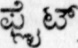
ಫ್ಲೈಟ್
